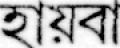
হায়বা
